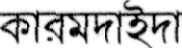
কারমদাইদা
